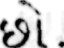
છો.
